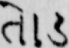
તોડ
